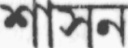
শাসন
